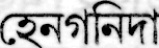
হেনগনিদা
